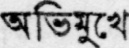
অভিমুখে
